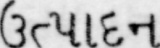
ઉત્પાદન
